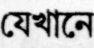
যেখানে
